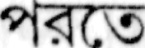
পরতে
